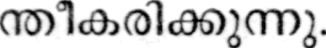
ന്തീകരിക്കുന്നു.
